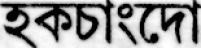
হকচাংদো
